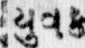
યુવક
